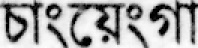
চাংয়েংগা
